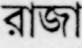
রাজা
